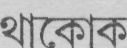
থাকোক
